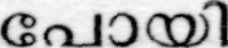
പോയി
